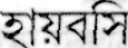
হায়বসি
